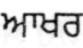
ਆਖਰ
